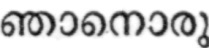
ഞാനൊരു
